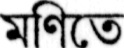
মণিতে
